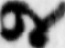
જ
